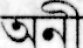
অনী
